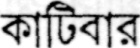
কাটিবার
